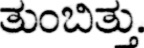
ತುಂಬಿತ್ತು.
